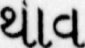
થાવ
